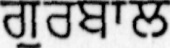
ਗੁਰਬਾਲ
